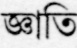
জ্ঞাতি
